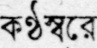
কণ্ঠস্বরে
